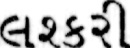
લશ્કરી
